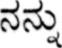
ನನ್ನು
